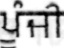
ਪੂੰਜੀ
